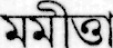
মমীত্তা
